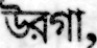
উরগা,
